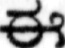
ಈ
